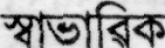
স্বাভাৱিক
